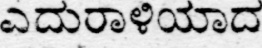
ಎದುರಾಳಿಯಾದ
